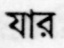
যার
